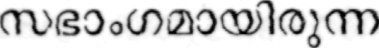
സഭാംഗമായിരുന്ന
